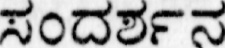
ಸಂದರ್ಶನ
